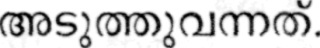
അടുത്തുവന്നത്.
